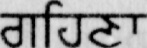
ਗਹਿਣਾ
